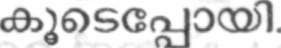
കൂടെപ്പോയി.
